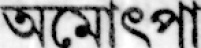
অমোৎপা
